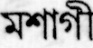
মশাগী
